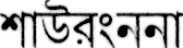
শাউরংননা
